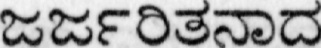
ಜರ್ಜರಿತನಾದ
